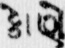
કોણે
